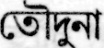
তৌদুনা
